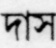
দাস
